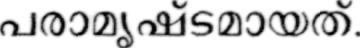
പരാമൃഷ്ടമായത്.
